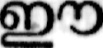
ഈ
